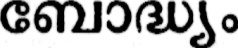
ബോദ്ധ്യം
